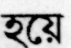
হয়ে
